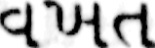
વખત
